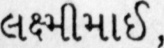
લક્ષ્મીબાઈ,
